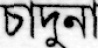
চাদুনা
